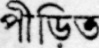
পীড়িত
